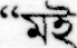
"মই
